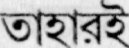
তাহারই
